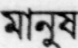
মানুষ
